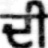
ਦੀ
